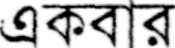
একবার
